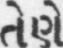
તેણે
